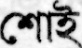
শোই
